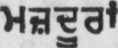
ਮਜ਼ਦੂਰਾਂ
